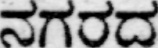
ನಗರದ
